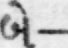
બે-
